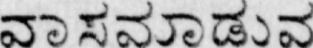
ವಾಸಮಾಡುವ
